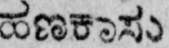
ಹಣಕಾಸು
